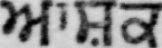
ਆਸ਼ਕ
